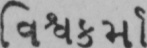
વિશ્વકર્મા
